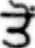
ਤੋਂ
